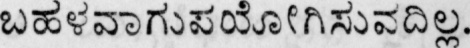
ಬಹಳವಾಗುಪಯೋಗಿಸುವದಿಲ್ಲ.
